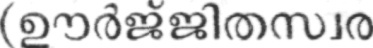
(ഊര്‍ജ്ജിതസ്വര
